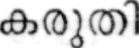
കരുതി
